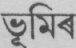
ভূমিৰ
